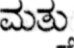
ಮತ್ತು
